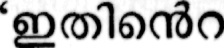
‘ഇതിന്റെ
